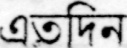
এতদিন
